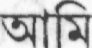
আমি
